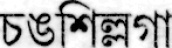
চঙশিল্লগা
